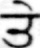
ਤੇ
